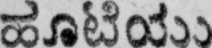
ಹೂಟೆಯು
